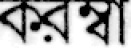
করম্বা
